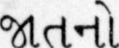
જાતનો
